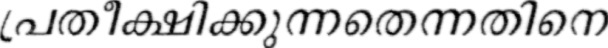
പ്രതീക്ഷിക്കുന്നതെന്നതിനെ
